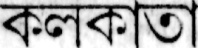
কলকাতা
